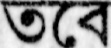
তবে
